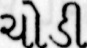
ચોડી
